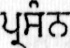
ਪ੍ਰਸੰਨ
